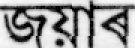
জয়াৰ
